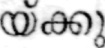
യ്ക്കു
